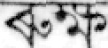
ৰুক্ষ
